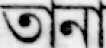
তানা
